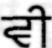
ਵੀ
